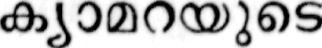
ക്യാമറയുടെ
